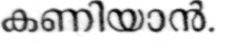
കണിയാന്‍.
